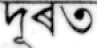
দূৰত
